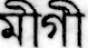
মীগী
